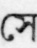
সে
